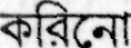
করিনো
